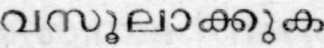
വസൂലാക്കുക
